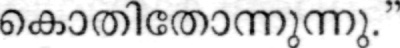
കൊതിതോന്നുന്നു.”
